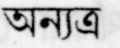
অন্যত্র
